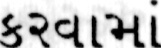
કરવામાં
